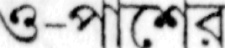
ও-পাশের
